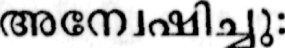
അന്വേഷിച്ചു:
